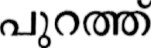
പുറത്ത്
